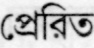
প্রেরিত
